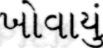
ખોવાયું
